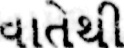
વાતેથી
